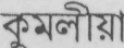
কুমলীয়া
